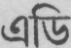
এড়ি
